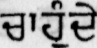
ਚਾਹੁੰਦੇ
